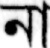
না
